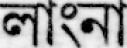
লাংনা
